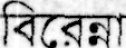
বিরেন্না
